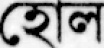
হোল
